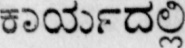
ಕಾರ್ಯದಲ್ಲಿ
